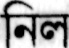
নিল
